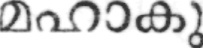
മഹാകു
